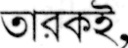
তারকই,
